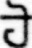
ਹੋ
